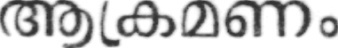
ആക്രമണം
